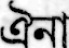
ঐনা
